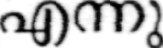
എന്നു
